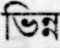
ভিন্ন
